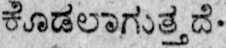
ಕೊಡಲಾಗುತ್ತದೆ.
